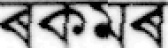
ৰকমৰ
